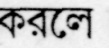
করলে
